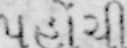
પહોંચી
